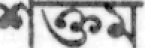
শক্তম
